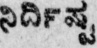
ನಿರ್ದಿಷ್ಟ
